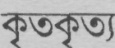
কৃতকৃত্য
